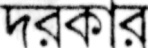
দরকার
